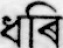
ধৰি
